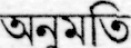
অনুমতি
